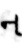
ન
